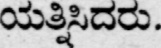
ಯತ್ನಿಸಿದರು.
